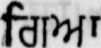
ਗਿਆ
